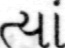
ત્યાં
